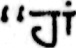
''ਹਾਂ
